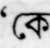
‘কে
